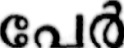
പേര്‍
